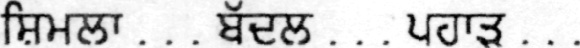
ਸ਼ਿਮਲਾ...ਬੱਦਲ...ਪਹਾੜ...
